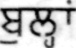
ਬੁਲ੍ਹਾਂ
